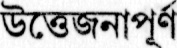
উত্তেজনাপূর্ণ
